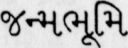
જન્મભૂમિ
